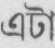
এটা
